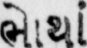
ભોથાં
